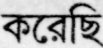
করেছি
